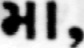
મા,
